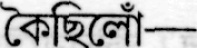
কৈছিলোঁ-
